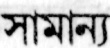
সামান্য
